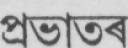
প্ৰভাতৰ
